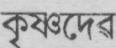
কৃষ্ণদেৱ
